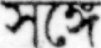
সঙ্গে
